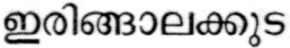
ഇരിങ്ങാലക്കുട
